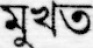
মুখত
